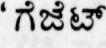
‘ಗೆಜೆಟ್
